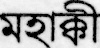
মহাক্কী
